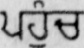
ਪਹੁੰਚ
